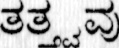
ತತ್ತ್ವವು
